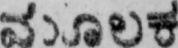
ಮೂಲಕ
